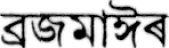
ব্রজমাঈৰ
